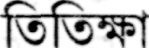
তিতিক্ষা
